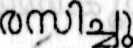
രസിച്ചു
